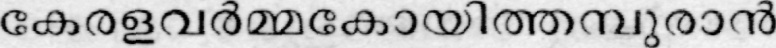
കേരളവര്‍മ്മകോയിത്തമ്പുരാന്‍
